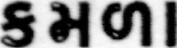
કમળા
